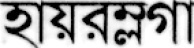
হায়রম্লগা
